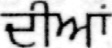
ਦੀਆਂ
